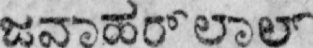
ಜವಾಹರ್‌ಲಾಲ್
